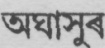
অঘাসুৰ
